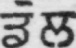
ਡੋਲ
